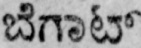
ಬೆಗಾಟ್
